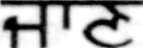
ਜਾਣ
